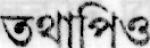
তথাপিও
